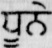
ਧੂਨੇ
